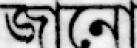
জানো
